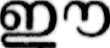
ഈ
